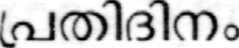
പ്രതിദിനം
